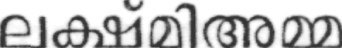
ലക്ഷ്മിഅമ്മ
